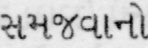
સમજવાનો
